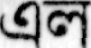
এল
